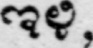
ಇಳಿ,
